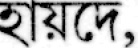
হায়দে,
